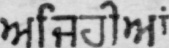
ਅਜਿਹੀਆਂ
